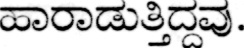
ಹಾರಾಡುತ್ತಿದ್ದವು.
